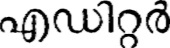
എഡിറ്റര്‍
